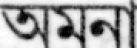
অমনা
